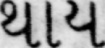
થાય
